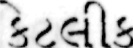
કેટલીક
